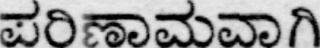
ಪರಿಣಾಮವಾಗಿ
